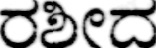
ರಶೀದ
